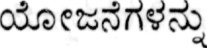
ಯೋಜನೆಗಳನ್ನು
